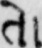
તો
